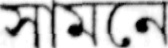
সামনে
